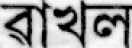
ৱাখল
